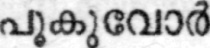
പൂകുവോര്‍
